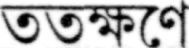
ততক্ষণে
